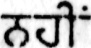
ਨਹੀਂ
